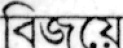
বিজয়ে
